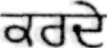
ਕਰਦੇ
